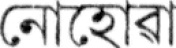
নোহোৱা
